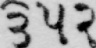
ઉપર
